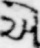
એ
